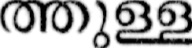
ത്തുള്ള
